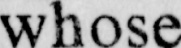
whose
